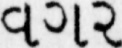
વગર
